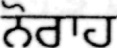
ਨੋਰਾਹ
